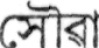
সৌৱা
